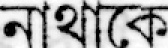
নাথাকে
